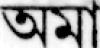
অমা
